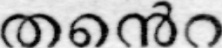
തന്റെ
